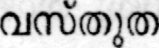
വസ്തുത
